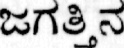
ಜಗತ್ತಿನ
